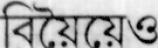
বিয়ৈয়েও
